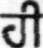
ਹੀ
